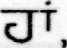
ਹਾਂ,
